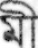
মী
